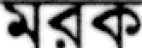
মরক
